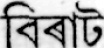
বিৰাট
